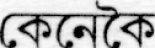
কেনেকৈ
